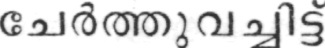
ചേര്‍ത്തുവച്ചിട്ട്
